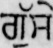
ਗੁੱਸੇ
